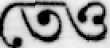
তেও
